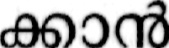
ക്കാന്‍
